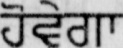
ਹੋਵੇਗਾ
